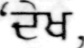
'ਦੇਖ,
